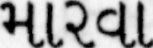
મારવા
